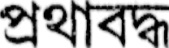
প্রথাবদ্ধ
